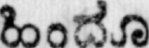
ಹಿಂದೂ
